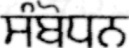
ਸੰਬੋਧਨ
